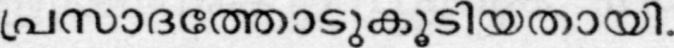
പ്രസാദത്തോടുകൂടിയതായി.
